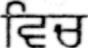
ਵਿਚ
